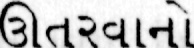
ઊતરવાનો
